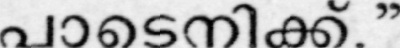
പാടെനിക്ക്."
